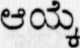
ಆಯ್ಕೆ
